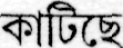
কাটিছে
